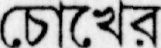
চোখের
